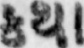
કથા
